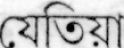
যেতিয়া
